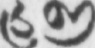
હજી
